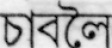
চাবলৈ
